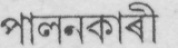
পালনকাৰী
